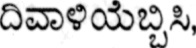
ದಿವಾಳಿಯೆಬ್ಬಿಸಿ,
